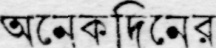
অনেকদিনের
